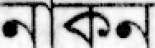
নাকন
